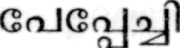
പേപ്പേച്ചി
